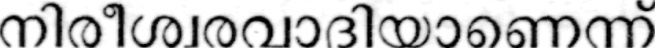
നിരീശ്വരവാദിയാണെന്ന്
